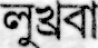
লুখ্রবা
